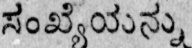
ಸಂಖ್ಯೆಯನ್ನು
